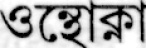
ওন্থোক্না
